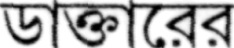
ডাক্তারের
